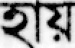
হায়
